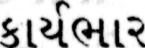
કાર્યભાર
